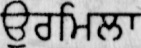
ਉਰਮਿਲਾ
